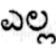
ಎಲ್ಲ
